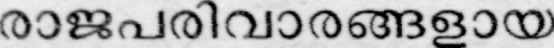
രാജപരിവാരങ്ങളായ
